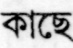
কাছে
